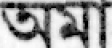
অমা
